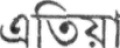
এতিয়া
